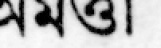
অমত্তা
